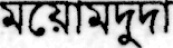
ময়োমদুদা
